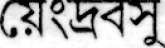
য়েংদ্রবসু
